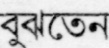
বুঝতেন
